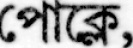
পোক্লে,
